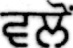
ਵਲੋਂ
